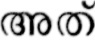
അത്
